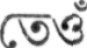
তেওঁ
